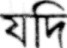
যদি
